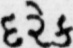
દરેક
